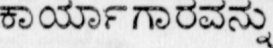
ಕಾರ್ಯಗಾರವನ್ನು
